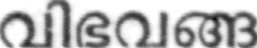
വിഭവങ്ങ
